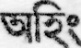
অহিং
